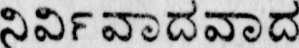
ನಿರ್ವಿವಾದವಾದ
